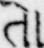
તો
